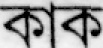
কাক
